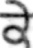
ਕੇ
